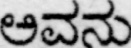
ಅವನು
